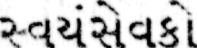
સ્વયંસેવકો
